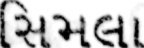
સિમલા
